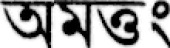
অমত্তং
